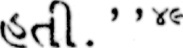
હતી."૪૯
